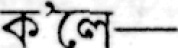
ক'লে-
